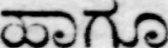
ಹಾಗೂ
